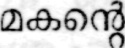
മകന്റെ
